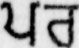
ਪਰ
